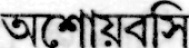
অশোয়বসি
